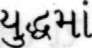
યુદ્ધમાં
